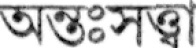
অন্তঃসত্ত্বা
